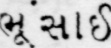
ભૂંસાઈ
